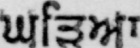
ਘੜਿਆ
